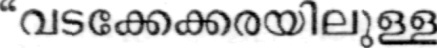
“വടക്കേക്കരയിലുള്ള
